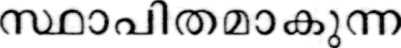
സ്ഥാപിതമാകുന്ന
